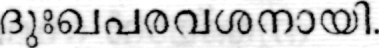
ദുഃഖപരവശനായി.
